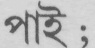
পাই;
